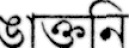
ঙাক্তনি
